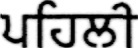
ਪਹਿਲੀ
